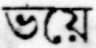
ভয়ে
